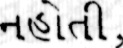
નહોતી,
